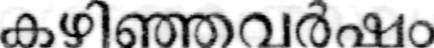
കഴിഞ്ഞവര്‍ഷം
